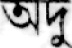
অদু
